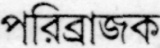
পরিব্রাজক
